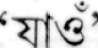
'যাওঁ'
